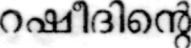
റഷീദിന്റെ
